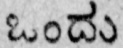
ಒಂದು
